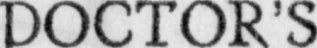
DOCTOR’S
